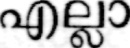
എല്ലാ
